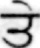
ਤੇ
